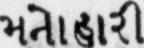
મનોહારી
